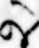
જે
